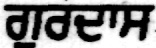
ਗੁਰਦਾਸ
